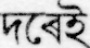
দৰেই
